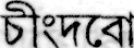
চীংদবো
